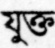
যুক্ত
